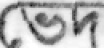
ভেদ
